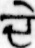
ਦੇ
